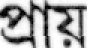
প্রায়
